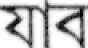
যাব
